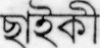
ছাইকী
